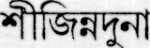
শীজিন্নদুনা
